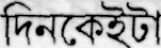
দিনকেইটা
